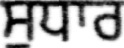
ਸੁਧਾਰ
